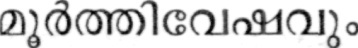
മൂര്‍ത്തിവേഷവും
